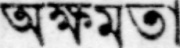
অক্ষমতা
